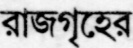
রাজগৃহের
